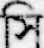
সি
